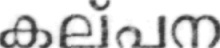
കല്പന
